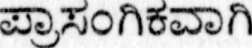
ಪ್ರಾಸಂಗಿಕವಾಗಿ
